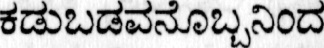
ಕಡುಬಡವನೊಬ್ಬನಿಂದ
